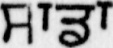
ਸਾਡਾ
